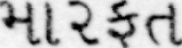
મારફત
